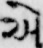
એ
